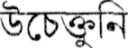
উচেক্তুনি
